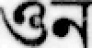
ওন
